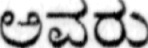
ಅವರು
